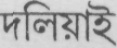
দলিয়াই
